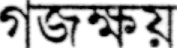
গজক্ষয়
